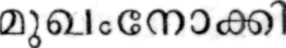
മുഖംനോക്കി
